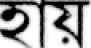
হায়
